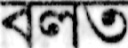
বলত
